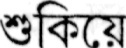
শুকিয়ে
